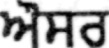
ਔਸਰ
